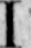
I
